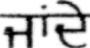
ਜਾਂਦੇ
